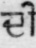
ਦੀ
